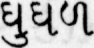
ઘુઘળ
